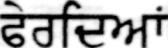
ਫੇਰਦਿਆਂ
